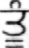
ਤੂੰ
